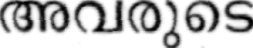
അവരുടെ
